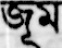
জূম
